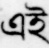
এই
